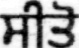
ਸੀਤੋ
